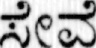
ಸೇವೆ
